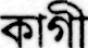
কাগী
